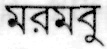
মরমবু
